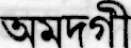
অমদগী
